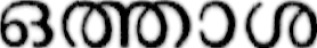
ഒത്താശ
